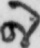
જે
